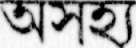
অসহ্য
